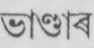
ভাণ্ডাৰ
